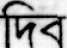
দিব
